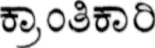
ಕ್ರಾಂತಿಕಾರಿ
